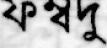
ফম্বদু
